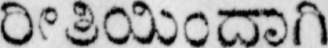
ರೀತಿಯಿಂದಾಗಿ
